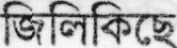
জিলিকিছে
